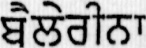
ਬੈਲੇਰੀਨਾ
